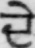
ਦੇ
